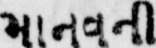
માનવની
